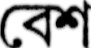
বেশ
